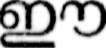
ഈ
